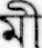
মী
